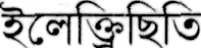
ইলেক্ত্রিছিতি
